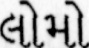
લોમો
